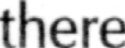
there
